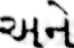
અને
